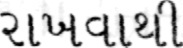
રાખવાથી
